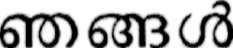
ഞങ്ങള്‍
